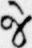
જે
